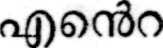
എന്റെ
